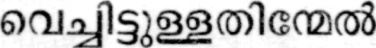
വെച്ചിട്ടുള്ളതിന്മേല്‍
